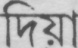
দিয়া
